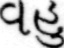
વહુ
